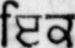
ਇਕ
